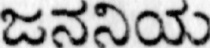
ಜನನಿಯ
